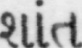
શાંત
